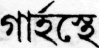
গার্হস্থে
